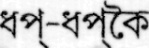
ধপ্‌-ধপ‌্কৈ
